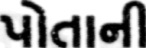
પોતાની
